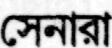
সেনারা
